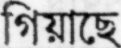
গিয়াছে
